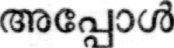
അപ്പോള്‍
